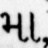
મા,
